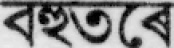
বহুতৰে
